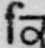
ਕਿ
